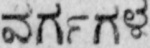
ವರ್ಗಗಳ
